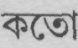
কতো
